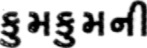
કુમકુમની
